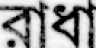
রাধা
